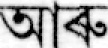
আৰু
